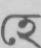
হে
